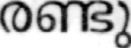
രണ്ടു
